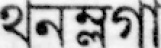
থনম্লগা
